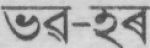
ভৱ-হৰ
